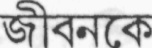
জীবনকে
